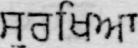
ਸੁਰਖਿਆ
